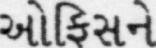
ઓફિસને
